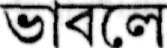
ভাবলে
